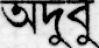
অদুবু
